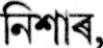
নিশাৰ,
